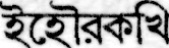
ইহৌরকখি
